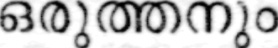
ഒരുത്തനും
